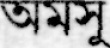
অমসু
